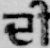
ਦੀ
